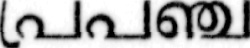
പ്രപഞ്ച
